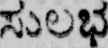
ಸುಲಭ
